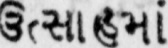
ઉત્સાહમાં
